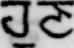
ਹੁਣ
